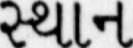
સ્થાન
